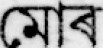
মোৰ
